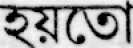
হয়তো
